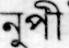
নুপী
